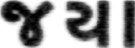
જયા
